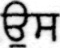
ਉਸ
